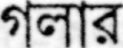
গলার
